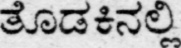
ತೊಡಕಿನಲ್ಲಿ
